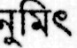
নুমিৎ
